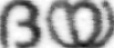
ദയ
